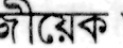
জীয়েক
